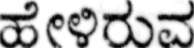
ಹೇಳಿರುವ
